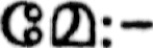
മേ:-
